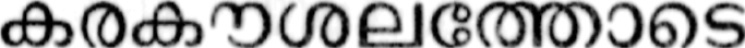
കരകൌശലത്തോടെ
